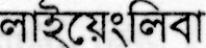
লাইয়েংলিবা
